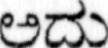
ಅದು
